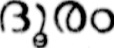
ദൂരം
